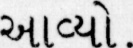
આવ્યો.
